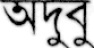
অদুবু
